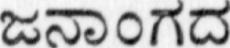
ಜನಾಂಗದ
